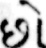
છો
